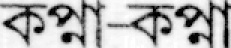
কপ্না-কপ্না
